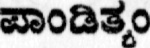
ಪಾಂಡಿತ್ಯಂ
